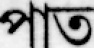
পাত
